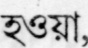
হওয়া,
